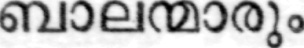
ബാലന്മാരും
